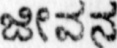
ಜೀವನ
